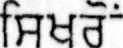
ਸਿਖਰੋਂ
